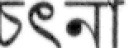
চৎনা
